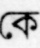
কে
